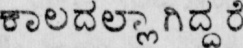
ಕಾಲದಲ್ಲಾಗಿದ್ದರೆ
